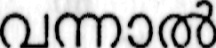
വന്നാല്‍
